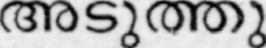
അടുത്തു
